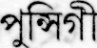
পুন্সিগী
